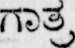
ಗಾತ್ರ
